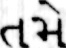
તમે
